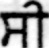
ਸੀ
